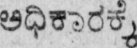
ಅಧಿಕಾರಕ್ಕೆ
